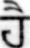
ਹੈ
